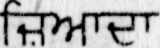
ਜ਼ਿਆਦਾ
